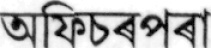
অফিচৰপৰা
